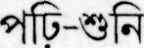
পঢ়ি-শুনি
